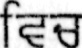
ਵਿਚ
